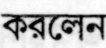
করলেন
